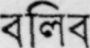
বলিব
